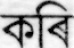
কৰি
